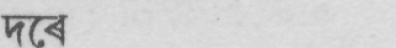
দৰে
